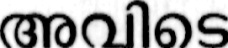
അവിടെ
